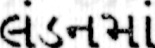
લંડનમાં
